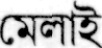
মেলাই
